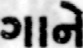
ગાને
